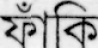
ফাঁকি
